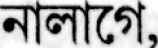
নালাগে,
